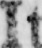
It
